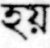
হয়
